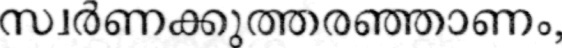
സ്വര്‍ണക്കുത്തരഞ്ഞാണം,
